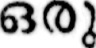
ഒരു
